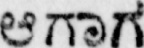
ಆಗಾಗ
